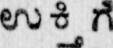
ಉಕ್ತಿಗೆ
